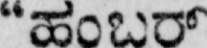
“ಹಂಬರ್
